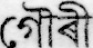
গৌৰী
